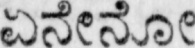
ಏನೇನೋ
